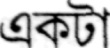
একটা
